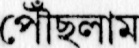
পৌঁছলাম
